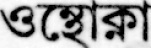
ওন্থোক্না
